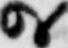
જ
